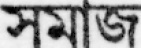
সমাজ
